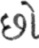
છો
